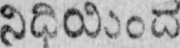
ನಿಧಿಯಿಂದ
